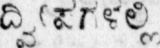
ದ್ವೀಪಗಳಲ್ಲಿ
